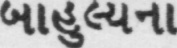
બાહુલ્યના
